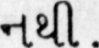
નથી.
